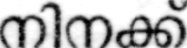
നിനക്ക്
